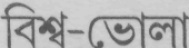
বিশ্ব-ভোলা
